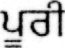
ਪੂਰੀ
